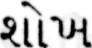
શોખ
